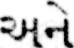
અને
